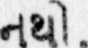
નથી.
